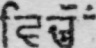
ਵਿਚੋਂ
